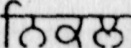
ਨਿਕਲ
